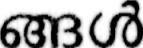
ങ്ങള്‍
